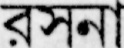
রসনা
